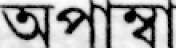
অপাম্বা
